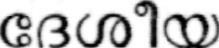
ദേശീയ
